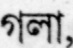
গলা,
